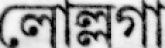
লোল্লগা
